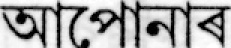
আপোনাৰ
